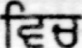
ਵਿਚ
